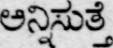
ಅನ್ನಿಸುತ್ತೆ
